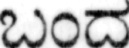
ಬಂದ
